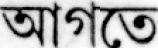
আগতে
